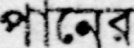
পানের
